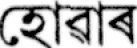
হোৱাৰ
